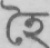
হৈ
